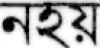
নহয়
